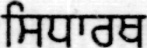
ਸਿਧਾਰਥ
